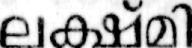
ലക്ഷ്മി
